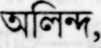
অলিন্দ,
